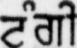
ਟੰਗੀ
